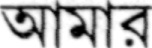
আমার
